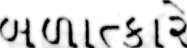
બળાત્કારે
